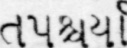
તપશ્ચર્યા
